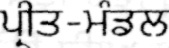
ਪ੍ਰੀਤ-ਮੰਡਲ
